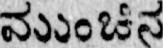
ಮುಂಚಿನ
